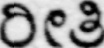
ರೀತಿ
